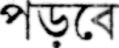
পড়বে
